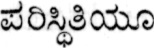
ಪರಿಸ್ಥಿತಿಯೂ
